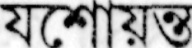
যশোয়ন্ত
